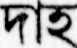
দাহ
